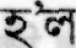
হ'ল
